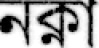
নক্না
